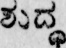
ಶುದ್ಧ
